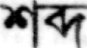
শব্দ
